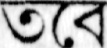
তবে
